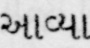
આવ્યા
